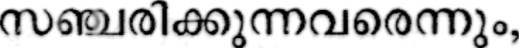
സഞ്ചരിക്കുന്നവരെന്നും,
